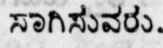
ಸಾಗಿಸುವರು.
